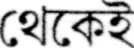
থেকেই
